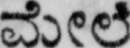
ಮೇಲೆ
